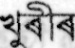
খুৰীৰ
